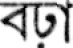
বঢ়া
